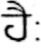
ਹੈ:
